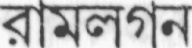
রামলগন
